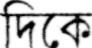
দিকে
